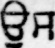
ਉਸ
